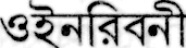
ওইনরিবনী
